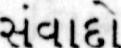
સંવાદો
